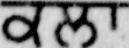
ਕਲਾ
